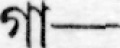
গা-
